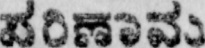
ಪರಿಣಾಮ
